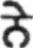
ਨੇ
